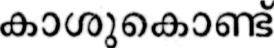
കാശുകൊണ്ട്
